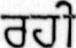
ਰਹੀ
